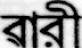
ৱারী
